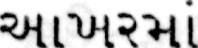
આખરમાં
